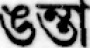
ঙন্তা
